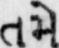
તમે
